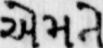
એમને
